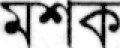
মশক
